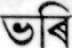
ভৰি
